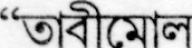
“তাবীমোল
